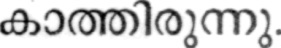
കാത്തിരുന്നു.
